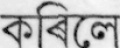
কৰিলে
